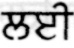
ਲਈ
